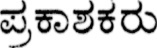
ಪ್ರಕಾಶಕರು
